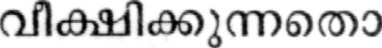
വീക്ഷിക്കുന്നതൊ
